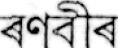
ৰণবীৰ
